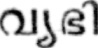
വ്യഭി
